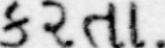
કરતા.
